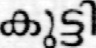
കുട്ടി
